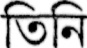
তিনি
